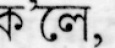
ক'লে,
